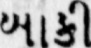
બાકી
